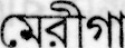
মেরীগা
